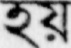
হয়
